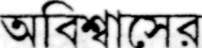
অবিশ্বাসের
